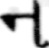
ન
